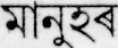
মানুহৰ
